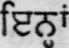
ਇਨ੍ਹਾਂ
